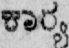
ಕಾರ್‍ಯ
